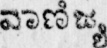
ವಾಣಿಜ್ಯ
